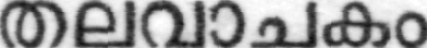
തലവാചകം
